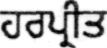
ਹਰਪ੍ਰੀਤ
